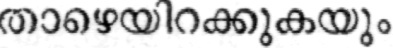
താഴെയിറക്കുകയും
